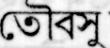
তৌবসু
